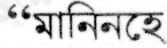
“মানিনহে
